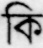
কি
